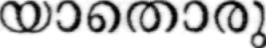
യാതൊരു
